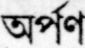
অর্পণ
